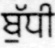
ਬੁੱਧੀ
